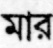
মার
